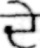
ਦੇ
